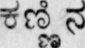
ಕಣ್ಣಿನ
